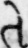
તે
